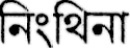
নিংথিনা
